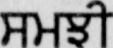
ਸਮਝੀ
